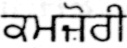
ਕਮਜ਼ੋਰੀ
